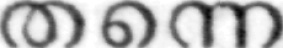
തന്നെ
